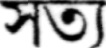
সত্য
